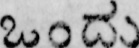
ಒಂದು
